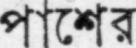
পাশের
